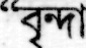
বৃন্দা
